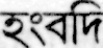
হংবদি
